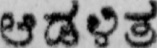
ಆಡಳಿತ
